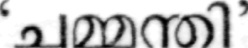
'ചമ്മന്തി'
